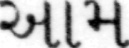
આમ
